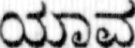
ಯಾವ
